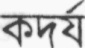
কদর্য
